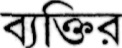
ব্যক্তির
